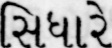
સિધારે
